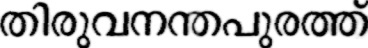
തിരുവനന്തപുരത്ത്
